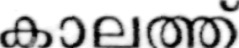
കാലത്ത്
